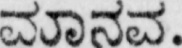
ಮಾನವ.
